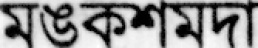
মঙকশমদা
